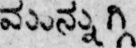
ಮುನ್ನುಗ್ಗಿ
